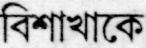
বিশাখাকে
